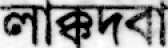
লাক্কদবা
